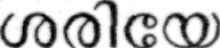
ശരിയേ
